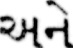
અને
